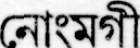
নোংমগী
